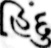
હિંદુ
